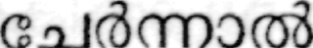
ചേര്‍ന്നാല്‍
